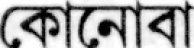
কোনোবা
